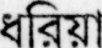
ধরিয়া
